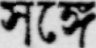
সঙ্গে
